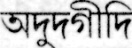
অদুদগীদি
